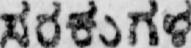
ಸರಕುಗಳ
